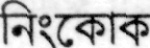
নিংকোক
